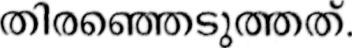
തിരഞ്ഞെടുത്തത്.
